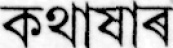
কথাষাৰ
